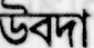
উবদা
